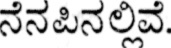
ನೆನಪಿನಲ್ಲಿವೆ.
